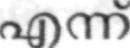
എന്ന്
